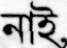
নাই,
